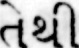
તેથી
